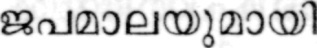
ജപമാലയുമായി
